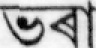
ভৰা
